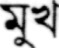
মুখ
